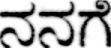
ನನಗೆ
